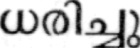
ധരിച്ചു
